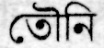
তৌনি
